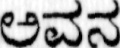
ಅವನ
